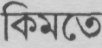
কিমতে
